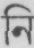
নি
